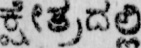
ಕ್ಷೇತ್ರದಲ್ಲಿ
